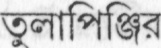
তুলাপিঞ্জির
